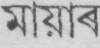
মায়াৰ
